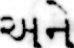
અને
